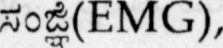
ಸಂಜ್ಞೆ(EMG),
